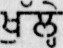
ਖੁੱਲ੍ਹੇ
